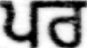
ਪਰ
